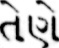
તેણે
